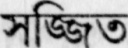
সজ্জিত
